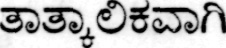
ತಾತ್ಕಾಲಿಕವಾಗಿ
